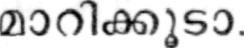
മാറിക്കൂടാ.
